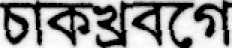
চাকখ্রবগে
